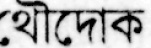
থৌদোক
